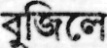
বুজিলে
